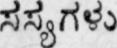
ಸಸ್ಯಗಳು
